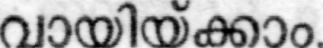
വായിയ്ക്കാം.
